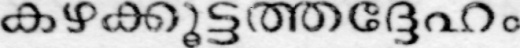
കഴക്കൂട്ടത്തദ്ദേഹം
